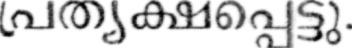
പ്രത്യക്ഷപ്പെട്ടു.
